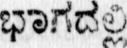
ಭಾಗದಲ್ಲಿ
